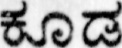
ಕೂಡ
